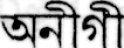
অনীগী
